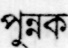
পুন্নক
